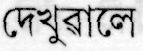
দেখুৱালে
